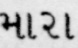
મારા
